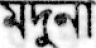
মদুনা
